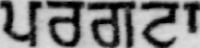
ਪਰਗਟਾ
